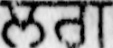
ਲਗ
